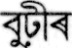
বুঢ়ীৰ
